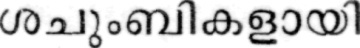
ശചുംബികളായി
